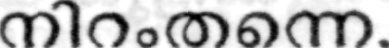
നിറംതന്നെ.
